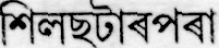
শিলছটাৰপৰা
